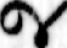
જ
